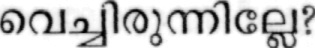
വെച്ചിരുന്നില്ലേ?
